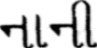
નાની
